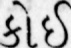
કોઈ
